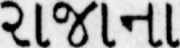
રાજાના
